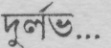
দুর্লভ...
